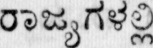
ರಾಜ್ಯಗಳಲ್ಲಿ
